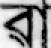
ৱা
